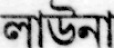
লাউনা
